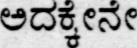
ಅದಕ್ಕೇನೇ
